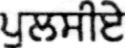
ਪੁਲਸੀਏ
